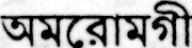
অমরোমগী
